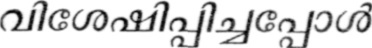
വിശേഷിപ്പിച്ചപ്പോള്‍
